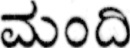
ಮಂದಿ
